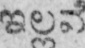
ಇಲ್ಲವೆ
